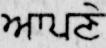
ਆਪਣੇ
